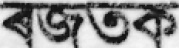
ৰজতক
